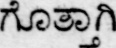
ಗೊತ್ತಾಗಿ
